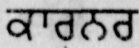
ਕਾਰਨਰ
